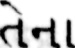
તેના
